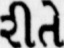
રીતે
